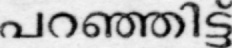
പറഞ്ഞിട്ട്
